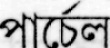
পার্চেল
